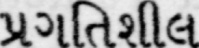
પ્રગતિશીલ
